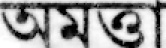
অমত্তা
